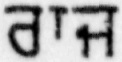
ਰਾਜ
